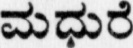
ಮಧುರೆ
